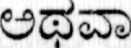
ಅಥವಾ
